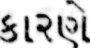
કારણે
